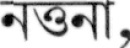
নত্তনা,
